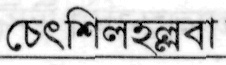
চেৎশিলহল্লবা
